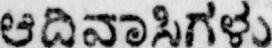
ಆದಿವಾಸಿಗಳು
